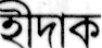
হীদাক
